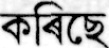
কৰিছে
